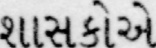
શાસકોએ
